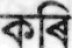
কৰি
